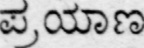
ಪ್ರಯಾಣ
